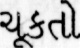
ચૂકતો
